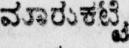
ಮಾರುಕಟ್ಟೆ
